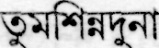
তুমশিন্নদুনা
